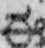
ಈ
